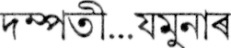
দম্পতী...যমুনাৰ
